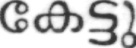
കേട്ടു
